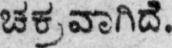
ಚಕ್ರವಾಗಿದೆ.
